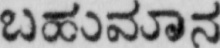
ಬಹುಮಾನ
